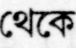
থেকে
